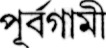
পূর্বগামী
